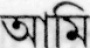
আমি
